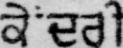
ਕੇਂਦਰੀ
